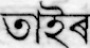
তাইৰ
